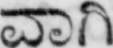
ವಾಗಿ
